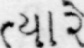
ત્યારે
